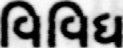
વિવિધ
